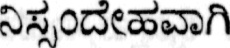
ನಿಸ್ಸಂದೇಹವಾಗಿ
